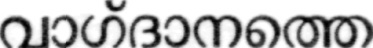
വാഗ്ദാനത്തെ
